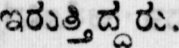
ಇರುತ್ತಿದ್ದರು.
